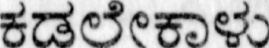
ಕಡಲೇಕಾಳು
